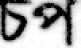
চপ
